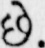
છે.
